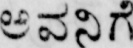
ಅವಗೆ
